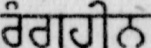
ਰੰਗਹੀਨ
